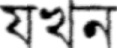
যখন
